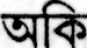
অকি
